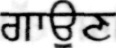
ਗਾਉਣ
